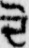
ਦੋ
